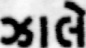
ઝાલે
